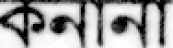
কনানা
